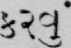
કરવું
